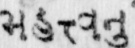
મહત્વનું
